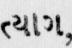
ત્યાગ,
